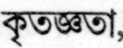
কৃতজ্ঞতা,
